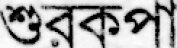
শুরকপা
